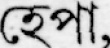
হেপা,
